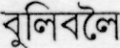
বুলিবলৈ
